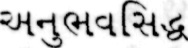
અનુભવસિદ્ધ
